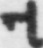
ન
